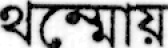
থম্মোয়
